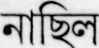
নাছিল
